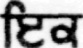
ਇਕ
